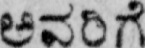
ಅವರಿಗೆ
